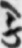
કે
